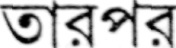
তারপর
